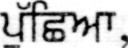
ਪੁੱਛਿਆ,
